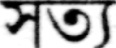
সত্য
